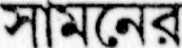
সামনের
